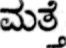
ಮತ್ತೆ
